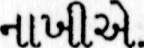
નાખીએ.
